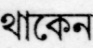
থাকেন
